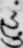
હું
